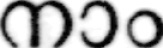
നാം
